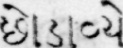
છોડાવ્યે
